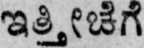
ಇತ್ತೀಚೆಗೆ
